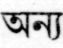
অন্য
